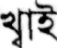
খ্বাই
